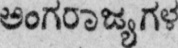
ಅಂಗರಾಜ್ಯಗಳ
